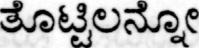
ತೊಟ್ಟಿಲನ್ನೋ
